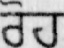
ਰੋਹ
